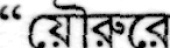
“য়ৌরুরে
